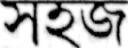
সহজ
